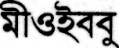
মীওইববু
